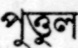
পুত্তুল
